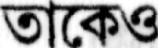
তাকেও
